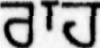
ਰਾਹ
